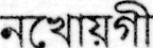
নখোয়গী
